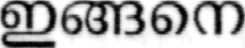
ഇങ്ങനെ
